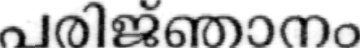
പരിജ്ഞാനം
